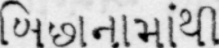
બિછાનામાંથી
